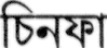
চিনফা
